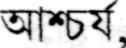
আশ্চর্য,
